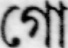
গো
